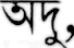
অদু,
